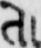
તો
